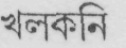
খলকনি
